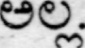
ಅಲ್ಲ.
